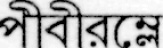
পীবীরম্লে
